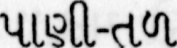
પાણી-તળ
